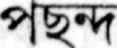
পছন্দ
